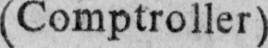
(Comptroller)
